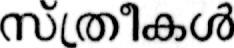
സ്ത്രീകള്‍
